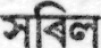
সৰিল
